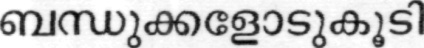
ബന്ധുക്കളോടുകൂടി
